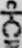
ਨੂੰ
